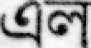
এল
